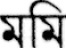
মমি
